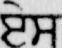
ਏਸ
